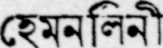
হেমনলিনী
